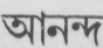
আনন্দ
